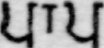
ਪਾਪ
